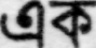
এক
